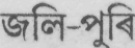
জলি-পুৰি
